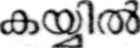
കയ്യില്‍
